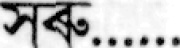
সৰু......
